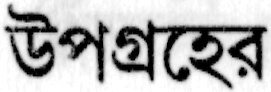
উপগ্রহের
